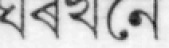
ঘৰখনে
